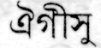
ঐগীসু
